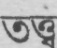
তত্ত্ব
